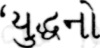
'યુદ્ધનો
